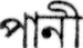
পানী
